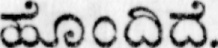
ಹೊಂದಿದೆ.
